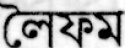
লৈফম
